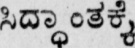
ಸಿದ್ದಾಂತಕ್ಕೆ
